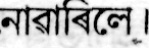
নোৱাৰিলে
